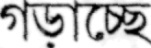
গড়াচ্ছে
